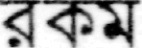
রকম
